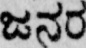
ಜನರ
